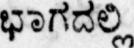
ಭಾಗದಲ್ಲಿ
